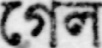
গেল
